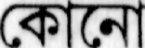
কোনো
